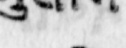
જાન
